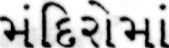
મંદિરોમાં
